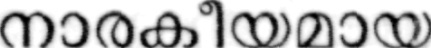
നാരകീയമായ
